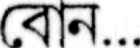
বোন...
